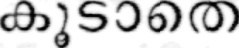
കൂടാതെ
